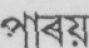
পাৰয়
